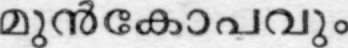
മുന്‍കോപവും
